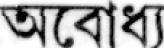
অবোধ্য
